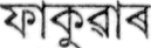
ফাকুৱাৰ
